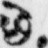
છે.
